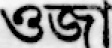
ওজা
